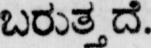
ಬರುತ್ತದೆ.
